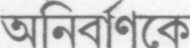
অনির্বাণকে
